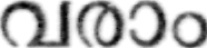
വരാം
